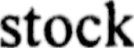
stock
